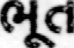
ભૂત
